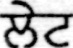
ਲੇਟ
